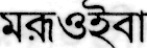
মরূওইবা
